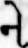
ને
